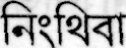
নিংথিবা
